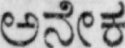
ಅನೇಕ
